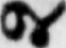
જ
